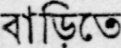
বাড়িতে
